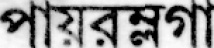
পায়রম্লগা
